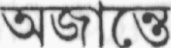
অজান্তে
